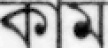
কাম
